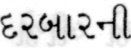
દરબારની
